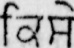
ਕਿਸੇ
